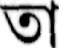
তা
